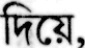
দিয়ে,
